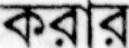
করার
